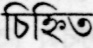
চিহ্নিত
